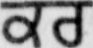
ਕਰ
